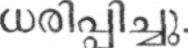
ധരിപ്പിച്ചു.
